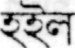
হইল
